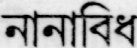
নানাবিধ
